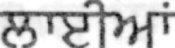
ਲਾਈਆਂ
